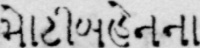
મોટીબહેનના
